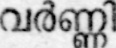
വര്‍ണ്ണി
